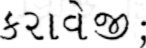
કરાવેજી;
